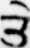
ਤੇ
